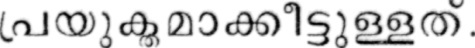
പ്രയുക്തമാക്കീട്ടുള്ളത്.
